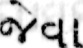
જેવા
